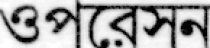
ওপরেসন
